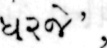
ધરજે',
